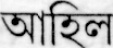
আহিল
